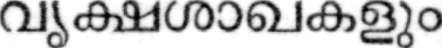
വൃക്ഷശാഖകളും
